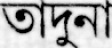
তাদুনা
